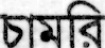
চামরি
